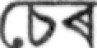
চেৰ
